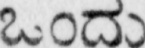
ಒಂದು
